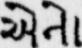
એનો
